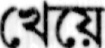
খেয়ে
